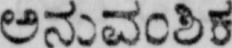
ಅನುವಂಶಿಕ
